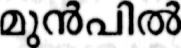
മുന്‍പില്‍
